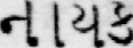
નાયક
